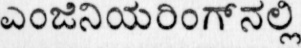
ಎಂಜಿನಿಯರಿಂಗ್‌ನಲ್ಲಿ
